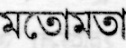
মতোমদা
